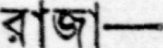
রাজা—
